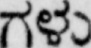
ಗಳು
